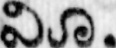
ಮೀ.
